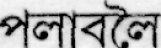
পলাবলৈ
